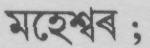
মহেশ্বৰ;
